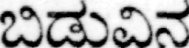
ಬಿಡುವಿನ
